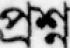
প্রশ্ন
